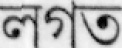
লগত
